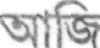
আজি
